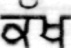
ਕੱਖ
